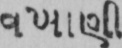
વખાણી
